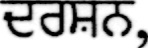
ਦਰਸ਼ਨ,
